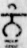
ਨੂੰ
